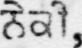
ਨੇਕੀ,
